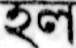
হল
